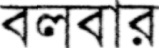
বলবার
